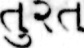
તુરત
